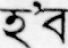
হ'ব
